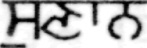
ਸੁਣਾਨ
